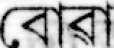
বোৱা
